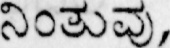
ನಿಂತುವು,
